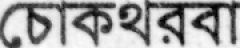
চোকথরবা
